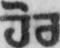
ਹੋਰ
